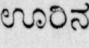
ಊರಿನ
